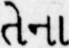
તેના
